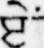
ਏਂ
